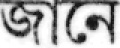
জানে
